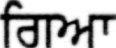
ਗਿਆ
